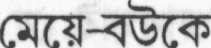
মেয়ে-বউকে
